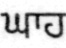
ਘਾਹ
